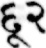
દૂર
